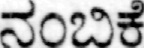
ನಂಬಿಕೆ
